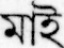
মাই
